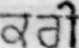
ਕਰੀ
